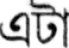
এটা
